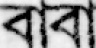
বাবা
